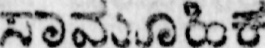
ಸಾಮೂಹಿಕ
